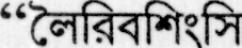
“লৈরিবশিংসি
